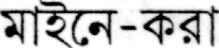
মাইনে-করা
